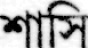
শাসি
